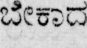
ಬೇಕಾದ
